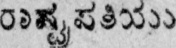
ರಾಷ್ಟ್ರಪತಿಯು
